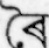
ৰৈ
